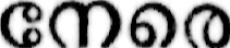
നേരെ
